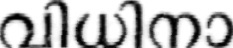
വിധിനാ
